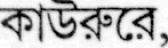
কাউরুরে,
